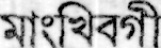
মাংখিবগী
